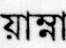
য়াম্না
